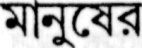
মানুষের
